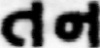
તન
